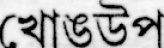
খোঙউপ
